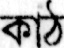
কাঠ
